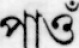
পাওঁ
